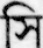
সি
